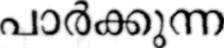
പാര്‍ക്കുന്ന
